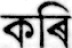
কৰি
